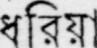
ধরিয়া
